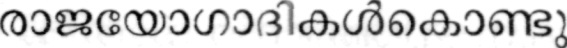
രാജയോഗാദികള്‍കൊണ്ടു
